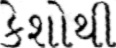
કેશોથી
